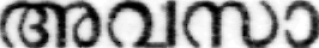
അവസാ
